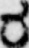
ರ
